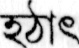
হঠাৎ
